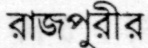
রাজপুরীর
